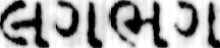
લગભગ
